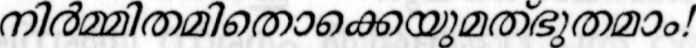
നിര്‍മ്മിതമിതൊക്കെയുമത്ഭുതമാം!
